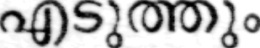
എടുത്തും
